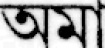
অমা
